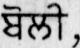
ਬੋਲੀ,
